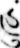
હુ
